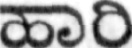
ಹಾರಿ
